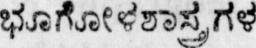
ಭೂಗೋಳಶಾಸ್ತ್ರಗಳ
